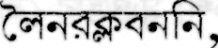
লৈনরক্লবননি,
